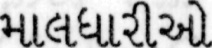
માલધારીઓ
